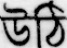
উঠি
